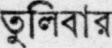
তুলিবার
